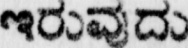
ಇರುವುದು
